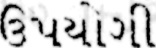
ઉપયોગી
